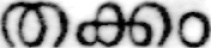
തക്കം
